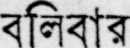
বলিবার
